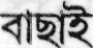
বাছাই
